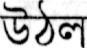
উঠল
